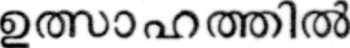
ഉത്സാഹത്തില്‍
